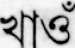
খাওঁ
